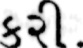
કરી.
